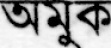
অমুক
